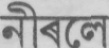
নীৰলে
